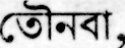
তৌনবা,
